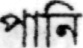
পানি
